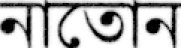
নাতোন
